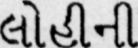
લોહીની
